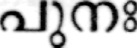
പുനഃ
